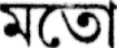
মতো
